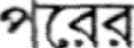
পরের
